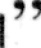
হায়দো
